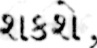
શકશે,
